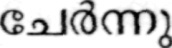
ചേര്‍ന്നു
